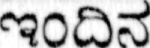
ಇಂದಿನ
